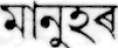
মানুহৰ
